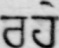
ਰਹੇ
